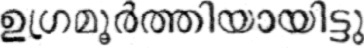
ഉഗ്രമൂര്‍ത്തിയായിട്ടു
